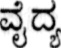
ವೈದ್ಯ
